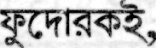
ফুদোরকই,
